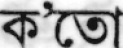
ক'তো
